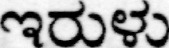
ಇರುಳು
